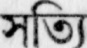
সত্যি
